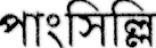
পাংসিল্লি
